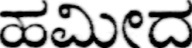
ಹಮೀದ
